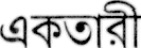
একতারী
